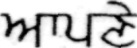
ਆਪਣੇ
